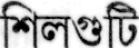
শিলগুটি
